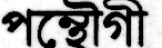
পন্থৌগী
